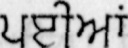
ਪਈਆਂ
